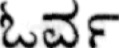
ಓರ್ವ
